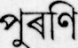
পুৰণি
